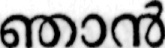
ഞാന്‍
